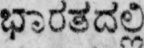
ಭಾರತದಲ್ಲಿ
